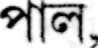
পাল,
